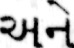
અને
